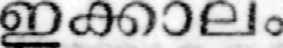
ഇക്കാലം
